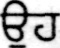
ਉਹ
